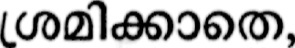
ശ്രമിക്കാതെ,
